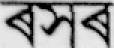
ৰসৰ
